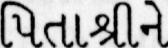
પિતાશ્રીને
